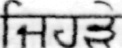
ਜਿਹੜੇ
